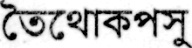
তৈথোকপসু
